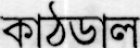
কাঠডাল
